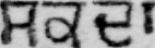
ਸਕਦਾ
